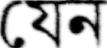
যেন
